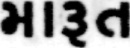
મારૂત
